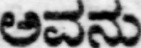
ಅವನು
